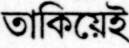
তাকিয়েই
